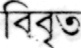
বিবৃত
